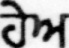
ਹੇਅ
